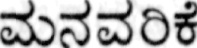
ಮನವರಿಕೆ
